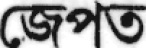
জেপত
